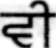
ਵੀ
